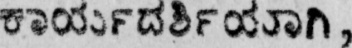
ಕಾರ್ಯದರ್ಶಿಯಾಗಿ,
